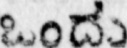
ಒಂದು
